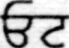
ਓਟ
